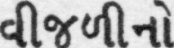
વીજળીનો
